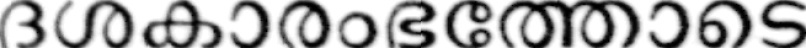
ദശകാരംഭത്തോടെ
